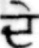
ਦੇ
